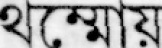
থম্মোয়
